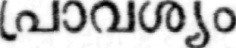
പ്രാവശ്യം
